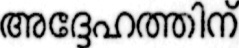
അദ്ദേഹത്തിന്
